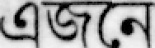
এজনে
